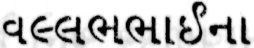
વલ્લભભાઈના
